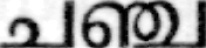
ചഞ്ച
